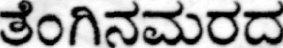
ತೆಂಗಿನಮರದ
